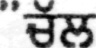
''ਚੱਲ
